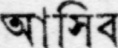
আসিব
